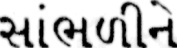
સાંભળીને
